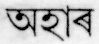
অহাৰ
